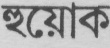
হুয়োক
